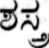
ಶಸ್ತ್ರ
